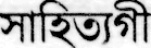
সাহিত্যগী
